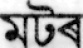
মটৰ
